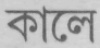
কালে
